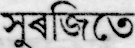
সুৰজিতে
